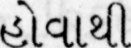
હોવાથી
